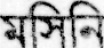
মসিনি
